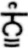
ਨੂੰ
